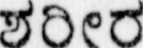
ಶರೀರ
